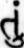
તું
